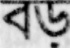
বড়
